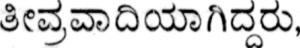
ತೀವ್ರವಾದಿಯಾಗಿದ್ದರು,
